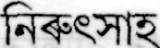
নিৰুৎসাহ
